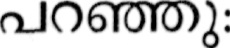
പറഞ്ഞു:
